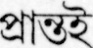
প্রান্তই
